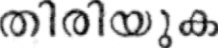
തിരിയുക
